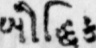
બૌદ્ધિક
